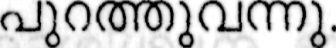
പുറത്തുവന്നു.
